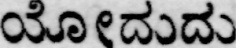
ಯೋದುದು
